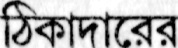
ঠিকাদারের
